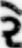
રે
